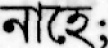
নাহে;
